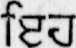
ਇਹ
